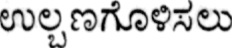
ಉಲ್ಬಣಗೊಳಿಸಲು
